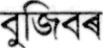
বুজিবৰ
